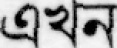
এখন
